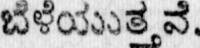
ಬೆಳೆಯುತ್ತವೆ.
